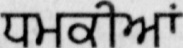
ਧਮਕੀਆਂ
